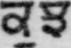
ਕੁਝ
